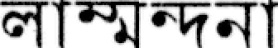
লাম্মন্দনা
